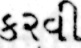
કરવી
